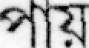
পায়
